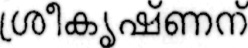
ശ്രീകൃഷ്ണന്
